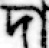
দা
